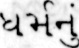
ધર્મનું
